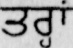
ਤਰ੍ਹਾਂ
